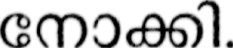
നോക്കി.
